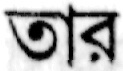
তার
